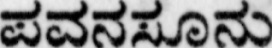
ಪವನಸೂನು
